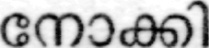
നോക്കി
